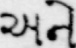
અને
